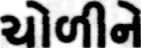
ચોળીને
